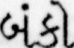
બંકો
